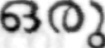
ഒരു
